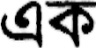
এক
